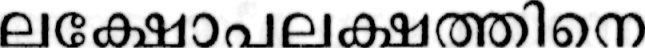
ലക്ഷോപലക്ഷത്തിനെ
